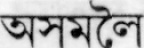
অসমলৈ
